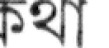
কথা
